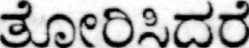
ತೋರಿಸಿದರೆ
